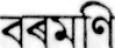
বৰমণি
